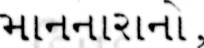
માનનારાનો,
